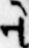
ને
